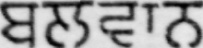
ਬਲਵਾਨ
